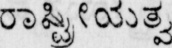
ರಾಷ್ಟ್ರೀಯತ್ವ
